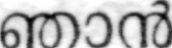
ഞാന്‍
